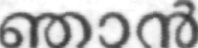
ഞാന്‍
